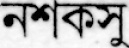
নশকসু
